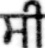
ਸੀ
